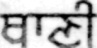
ਥਾਣੀ
